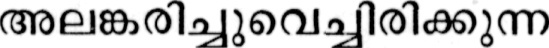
അലങ്കരിച്ചുവെച്ചിരിക്കുന്ന
